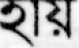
হায়
